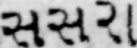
સસરા
